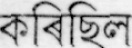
কৰিছিল
